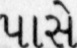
પાસે
